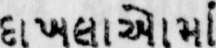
દાખલાઓમાં
